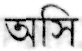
অসি
